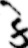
કે
